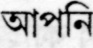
আপনি
